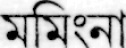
মমিংনা
